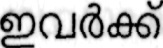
ഇവര്‍ക്ക്
